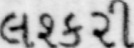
લશ્કરી
